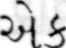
એક
